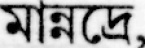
মান্নদ্রে,
